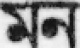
মন
